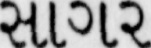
સાગર
